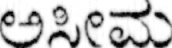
ಅಸೀಮ
